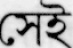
সেই
